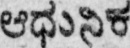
ಆಧುನಿಕ
